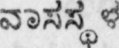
ವಾಸಸ್ಥಳ
